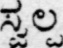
ಸ್ವಲ್ಪ
